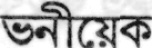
ভনীয়েক
